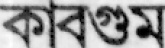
কাবগুম
